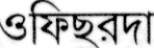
ওফিছরদা
